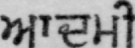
ਆਦਮੀ
